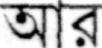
আর
